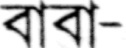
বাবা-
